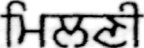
ਮਿਲਣੀ
